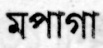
মপাগা
